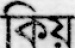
কিয়
